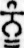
ਨੂੰ
